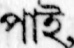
পাই,
